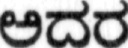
ಅದರ
